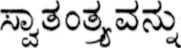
ಸ್ವಾತಂತ್ರ್ಯವನ್ನು
